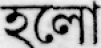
হলো
